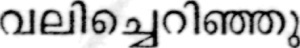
വലിച്ചെറിഞ്ഞു
